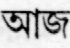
আজ
